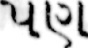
પણ
